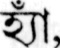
হ্যাঁ,
